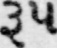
રૂપ
